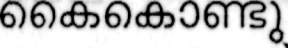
കൈകൊണ്ടു
